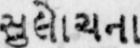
સુલોચના
